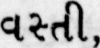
વસ્તી,
